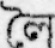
লৈ
